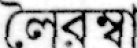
লৈরম্বা
